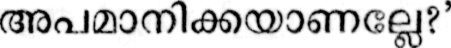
അപമാനിക്കയാണല്ലേ?’
